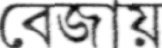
বেজায়
